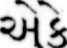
એકે
